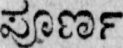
ಪೂರ್ಣ
